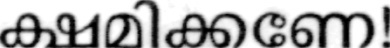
ക്ഷമിക്കണേ!
